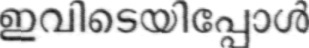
ഇവിടെയിപ്പോള്‍
